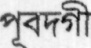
পূবদগী
